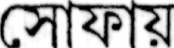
সোফায়
